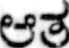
ಆತ
